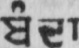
ਬੰਦਾ
